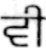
ਵੀ
